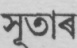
সূতাৰ
